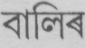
বালিৰ
